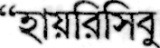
“হায়রিসিবু
